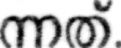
ന്നത്.
